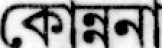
কোন্ননা
